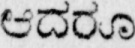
ಆದರೂ
